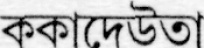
ককাদেউতা
